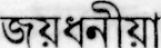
জয়ধনীয়া
